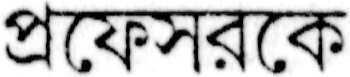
প্রফেসরকে
